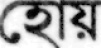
হোয়
